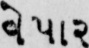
વેપાર
